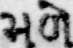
મળે
